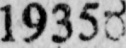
1935ರ
